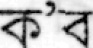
ক'ব
